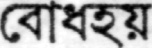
বোধহয়
